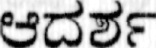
ಆದರ್ಶ
